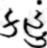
કહું
